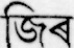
জিৰ
